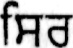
ਸਿਰ
